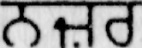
ਨਜ਼ਰ
